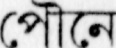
পৌনে
